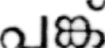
പങ്ക്
